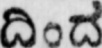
ದಿಂದ
